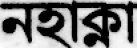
নহাক্না
